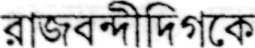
রাজবন্দীদিগকে
